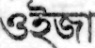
ওইজা
